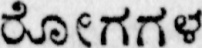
ರೋಗಗಳ
